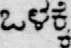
ಒಳಕ್ಕೆ
